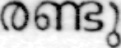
രണ്ടു
